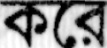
করে
